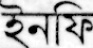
ইনফি
